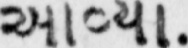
આવ્યા.
